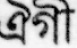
ঐগী
